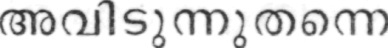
അവിടുന്നുതന്നെ
